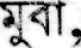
মুবা,
